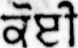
ਕੋਈ
